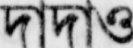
দাদাও
